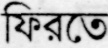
ফিরতে
